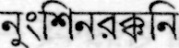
নুংশিনরক্কনি
